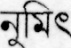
নুমিৎ
